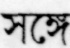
সঙ্গে
